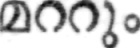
മററും
